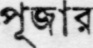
পূজার
